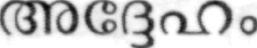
അദ്ദേഹം
